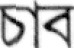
চাব
